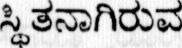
ಸ್ಥಿತನಾಗಿರುವ
